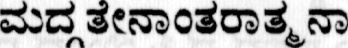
ಮದ್ಗತೇನಾಂತರಾತ್ಮನಾ
